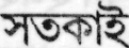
সতকাই
